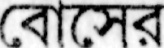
বোসের
